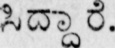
ಸಿದ್ದಾರೆ.
